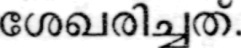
ശേഖരിച്ചത്.
